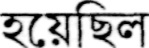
হয়েছিল
